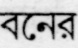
বনের
